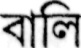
বালি
